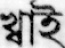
খ্বাই
